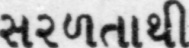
સરળતાથી
